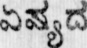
ಏಷ್ಯದ
